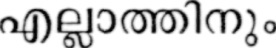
എല്ലാത്തിനും
